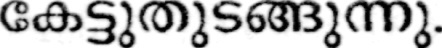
കേട്ടുതുടങ്ങുന്നു.
